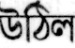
উঠিল
